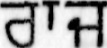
ਰਾਜ
